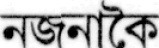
নজনাকৈ
